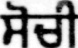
ਸੋਚੀ
